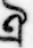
ঐ
